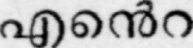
എന്റെ
